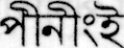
পীনীংই
